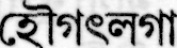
হৌগৎলগা
